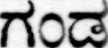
ಗಂಡ
